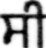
ਸੀ
